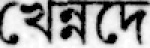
খেন্নদে
